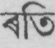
ৰতি
